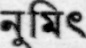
নুমিৎ
